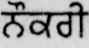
ਨੌਕਰੀ
